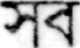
সব
